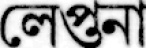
লেপ্তনা
